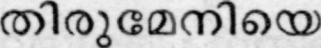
തിരുമേനിയെ
